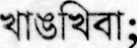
খাঙখিবা;
